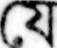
যে
